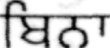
ਬਿਨਾ
